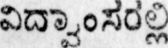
ವಿದ್ವಾಂಸರಲ್ಲಿ
